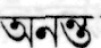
অনন্ত
